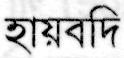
হায়বদি
